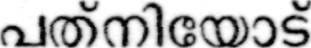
പത്നിയോട്
